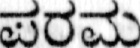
ಪರಮ
